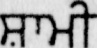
ਸ਼ਾਮੀ
